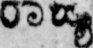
ರಾಜ್ಯ
